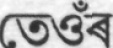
তেওঁৰ
